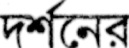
দর্শনের
